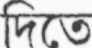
দিতে
